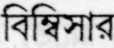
বিম্বিসার
